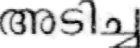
അടിച്ച
